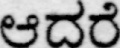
ಆದರೆ
